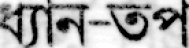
ধ্যান-তপ
